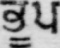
ਭੂਪ
